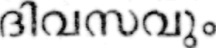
ദിവസവും
